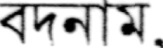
বদনাম,
